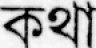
কথা
